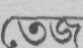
তেজ
